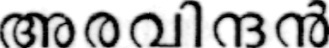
അരവിന്ദന്‍
